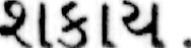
શકાય.
